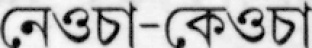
নেওচা-কেওচা
